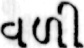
વળી
